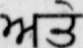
ਅਤੇ
